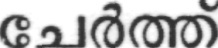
ചേര്‍ത്ത്
